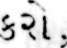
કરો,
